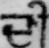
ਦੀ
